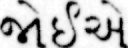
જોઈએ
